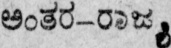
ಅಂತರ-ರಾಜ್ಯ
